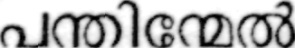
പന്തിന്മേല്‍
